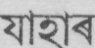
যাহাৰ
